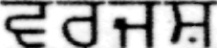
ਵਰਜਸ਼
